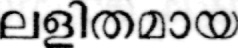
ലളിതമായ
